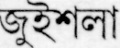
জুইশলা
